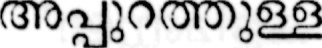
അപ്പുറത്തുള്ള
